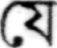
যে
